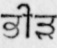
ਭੀੜ
